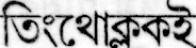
তিংথোক্লকই
